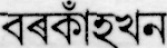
বৰকাঁহখন
